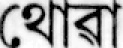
থোৱা
